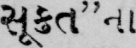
સૂક્ત”ના
